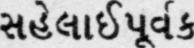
સહેલાઈપૂર્વક
